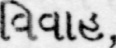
વિવાહ,
